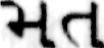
મત
